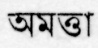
অমত্তা
